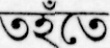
তহঁতে
